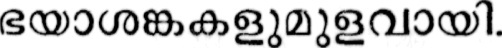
ഭയാശങ്കകളുമുളവായി.
